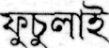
ফুচুলাই
